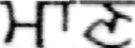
ਮਾਣ
